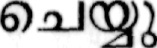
ചെയ്യു
